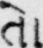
તો
